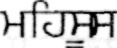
ਮਹਿਸੂਸ
